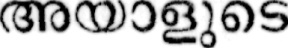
അയാളുടെ
